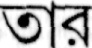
তার
